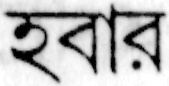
হবার
